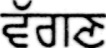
ਵੱਗਣ
